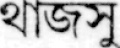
থাজসু
